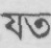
যত
